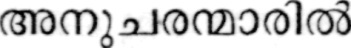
അനുചരന്മാരില്‍
